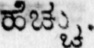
ಹೆಚ್ಚು.
